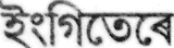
ইংগিতেৰে
